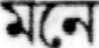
মনে
